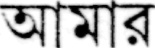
আমার
